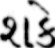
શકે
